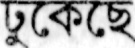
ঢুকেছে
